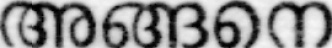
അങ്ങനെ
